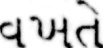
વખતે
